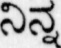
ನಿನ್ನ
